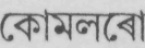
কোমলৰো
